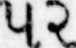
પર
